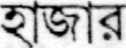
হাজার
